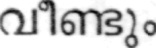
വീണ്ടും
